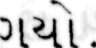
ગયો.
